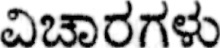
ವಿಚಾರಗಳು
